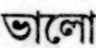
ভালো
